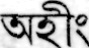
অহীং
